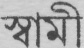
স্বামী
